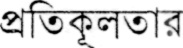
প্রতিকূলতার
